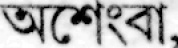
অশেংবা,
